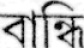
বান্ধি
